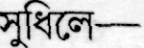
সুধিলে-
